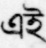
এই
